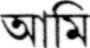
আমি
